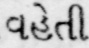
વહેતી
